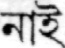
নাই
